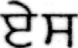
ਏਸ
